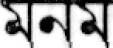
মনম
